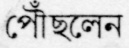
পৌঁছলেন
